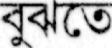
বুঝতে
